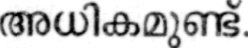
അധികമുണ്ട്.
